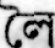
লৈ
